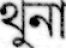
থুনা
